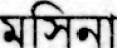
মসিনা
